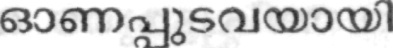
ഓണപ്പുടവയായി
